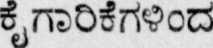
ಕೈಗಾರಿಕೆಗಳಿಂದ
